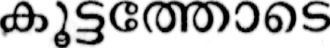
കൂട്ടത്തോടെ
